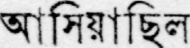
আসিয়াছিল
